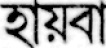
হায়বা
